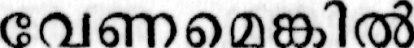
വേണമെങ്കില്‍
